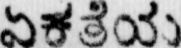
ಏಕತೆಯ
